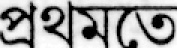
প্রথমতে
